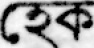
হেক
